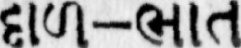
દાળ-ભાત
